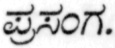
ಪ್ರಸಂಗ.
